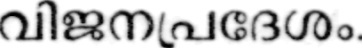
വിജനപ്രദേശം.
